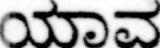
ಯಾವ
